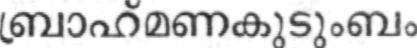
ബ്രാഹ്മണകുടുംബം
